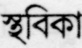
স্থবিকা
